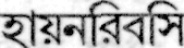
হায়নরিবসি
